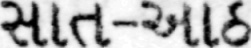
સાત-આઠ
